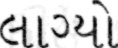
લાગ્યો
